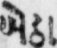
બેઠા
